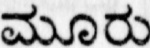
ಮೂರು
